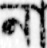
না
